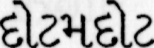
દોટમદોટ
